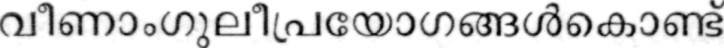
വീണാംഗുലീപ്രയോഗങ്ങള്‍കൊണ്ട്
